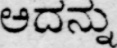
ಅದನ್ನು
